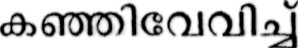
കഞ്ഞിവേവിച്ച്
